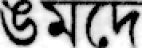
ঙমদে
